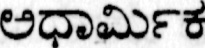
ಅಧಾರ್ಮಿಕ
